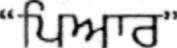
''ਪਿਆਰ''
